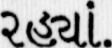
રહ્યાં.
